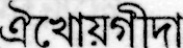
ঐখোয়গীদা
